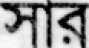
সার
